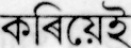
কৰিয়েই
